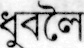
ধুবলৈ
